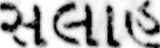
સલાહ
